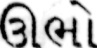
ઊભો
